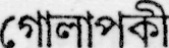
গোলাপকী
